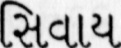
સિવાય
